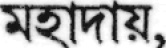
মহাদায়,
